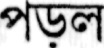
পড়ল
